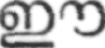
ഈ
